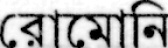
রোমোনি
